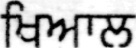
ਖਿਆਲ
